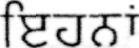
ਇਹਨਾਂ
